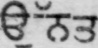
ਉੱਨਤ
